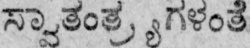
ಸ್ವಾತಂತ್ರ್ಯಗಳಂತೆ
